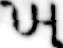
ખ
